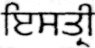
ਇਸਤ੍ਰੀ
